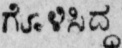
ಗೊಳಿಸಿದ್ಧ
